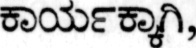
ಕಾರ್ಯಕ್ಕಾಗಿ,
